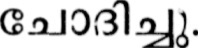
ചോദിച്ചു.
